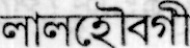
লালহৌবগী
